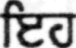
ਇਹ
